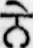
ਨੇ
